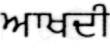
ਆਖਦੀ
